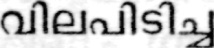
വിലപിടിച്ച
